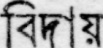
বিদায়
